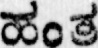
ಹಂತ
